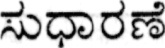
ಸುಧಾರಣೆ
